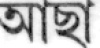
আছা
